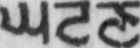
ਘਟਣ
